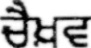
ਚੈਖ਼ਵ
